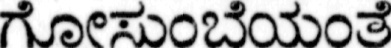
ಗೋಸುಂಬೆಯಂತೆ
